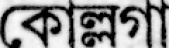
কোল্লগা
